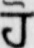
ਹੋ
